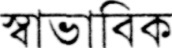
স্বাভাবিক
